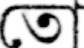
তো
